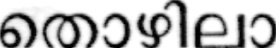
തൊഴിലാ
